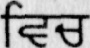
ਵਿਚ
